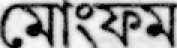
মোংফম
